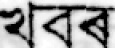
খবৰ
